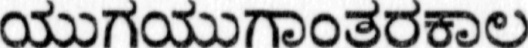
ಯುಗಯುಗಾಂತರಕಾಲ
